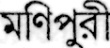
মণিপুরী
